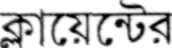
ক্লায়েন্টের
